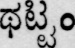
ಥಟ್ಟಂ
